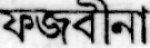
ফজবীনা
